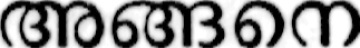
അങ്ങനെ
